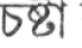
চেষ্টা
